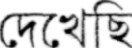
দেখেছি
